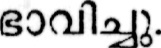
ഭാവിച്ചു.
